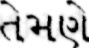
તેમણે
